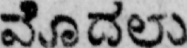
ಮೊದಲು
